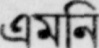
এমনি
